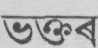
ভক্তৰ
